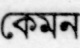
কেমন
